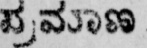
ಪ್ರಮಾಣ
